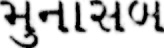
મુનાસબ
